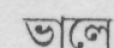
ভালে
